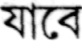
যাবে
